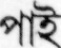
পাই
